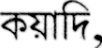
কয়াদি,
